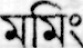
মমিং
